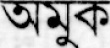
অমুক
